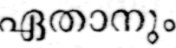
ഏതാനും
